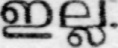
ഇല്ല.
